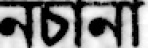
নচানা
